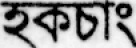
হকচাং
